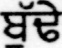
ਬੁੱਢੇ
